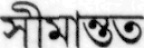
সীমান্তত
